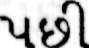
પછી
